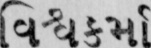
વિશ્વકર્મા
